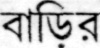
বাড়ির
